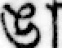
ঙা
